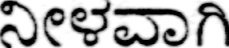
ನೀಳವಾಗಿ
